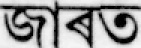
জাৰত
